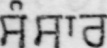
ਸੰਸਾਰ
